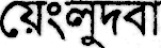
য়েংলুদবা
